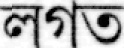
লগত
